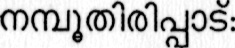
നമ്പൂതിരിപ്പാട്:
